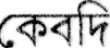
কেবদি
